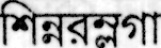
শিন্নরম্লগা
